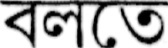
বলতে
